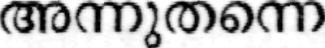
അന്നുതന്നെ
